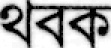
থবক
